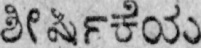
ಶೀರ್ಷಿಕೆಯ
